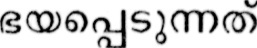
ഭയപ്പെടുന്നത്
